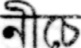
নীচে
